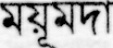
ময়ূমদা
